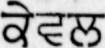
ਕੇਵਲ
